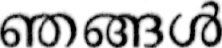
ഞങ്ങള്‍
